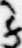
કે
